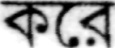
করে
